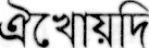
ঐখোয়দি
